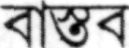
বাস্তব
